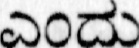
ಎಂದು
